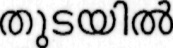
തുടയില്‍
